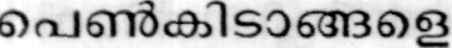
പെണ്‍കിടാങ്ങളെ
